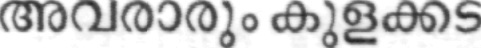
അവരാരുംകുളക്കട
